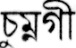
চুম্নগী
